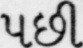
પછી
